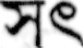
সৎ
